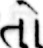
તો
